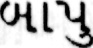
બાપુ
